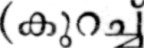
(കുറച്ച്
